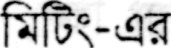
মিটিং-এর
